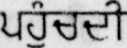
ਪਹੁੰਚਦੀ
